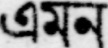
এমন
